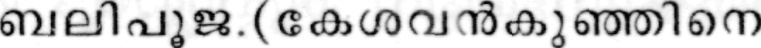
ബലിപൂജ.(കേശവന്‍കുഞ്ഞിനെ
